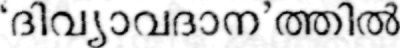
'ദിവ്യാവദാന'ത്തില്‍
